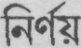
নিৰ্ণয়
